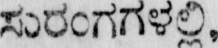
ಸುರಂಗಗಳಲ್ಲಿ,
